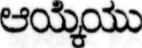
ಆಯ್ಕೆಯು
